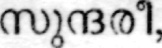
സുന്ദരീ,
